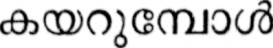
കയറുമ്പോള്‍
